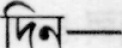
দিন-
